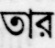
তার
